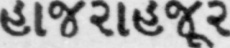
હાજરાહજૂર
